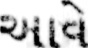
આવે
